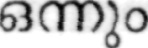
ഒന്നും
